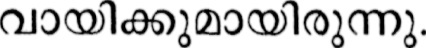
വായിക്കുമായിരുന്നു.
